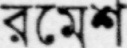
রমেশ
